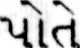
પોતે
